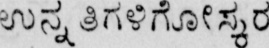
ಉನ್ನತಿಗಳಿಗೋಸ್ಕರ
